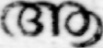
ആ
